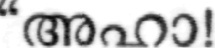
“അഹാ!
